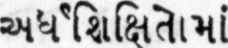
અર્ધશિક્ષિતોમાં
